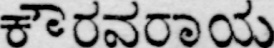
ಕೌರವರಾಯ
